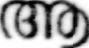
ആ
